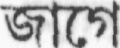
জাগে
